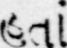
હતાં
